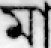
মা
